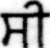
ਸੀ
